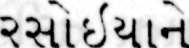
રસોઈયાને
